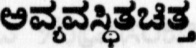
ಅವ್ಯವಸ್ಥಿತಚಿತ್ತ
